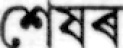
শেষৰ
